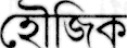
হৌজিক
